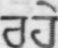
ਰਹੇ
